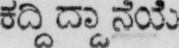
ಕದ್ದಿದ್ದಾನೆಯೆ
